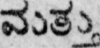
ಮತ್ತು
